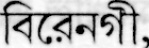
বিরেনগী,
